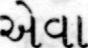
એવા
